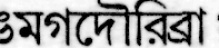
ঙমগদৌরিব্রা
